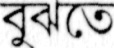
বুঝতে
